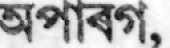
অপাৰগ,
